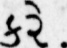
કરે.
